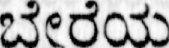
ಬೇರೆಯ
